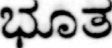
ಭೂತ
